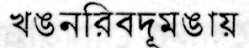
খঙনরিবদূমঙায়
